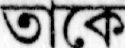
তাকে
